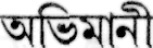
অভিমানী
